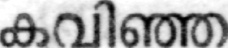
കവിഞ്ഞ
